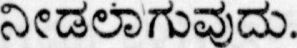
ನೀಡಲಾಗುವುದು.
